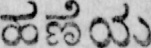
ಹಣೆಯ
